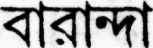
বারান্দা
